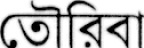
তৌরিবা
